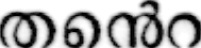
തന്റെ
